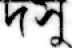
দসু
